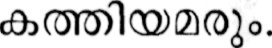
കത്തിയമരും.
